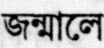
জন্মালে
